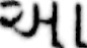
આ
